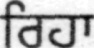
ਰਿਹਾ
